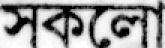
সকলো
